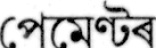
পেমেণ্টৰ
